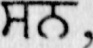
ਸਨ,
